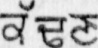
ਕੱਢਣ
